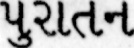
પુરાતન
